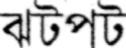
ঝটপট
